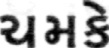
ચમકે
